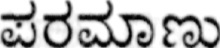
ಪರಮಾಣು
